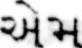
એક
